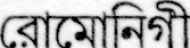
রোমোনিগী
